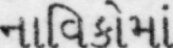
નાવિકોમાં
